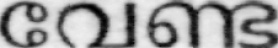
വേണ്ട
